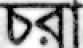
চরা
